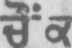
ਚੌਂਕ
